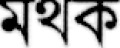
মথক
